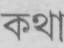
কথা
